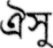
ঐসু
